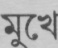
মুখে
